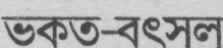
ভকত-বৎসল
